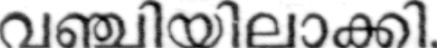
വഞ്ചിയിലാക്കി.
